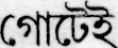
গোটেই
